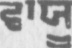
ਵਾਯੂ
